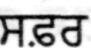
ਸਫ਼ਰ
